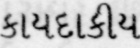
કાયદાકીય
